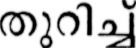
തുറിച്ച്
